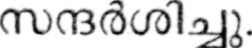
സന്ദര്‍ശിച്ചു.
